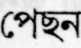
পেছন
